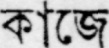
কাজে
